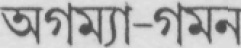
অগম্যা-গমন
